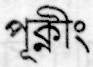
পূক্নীং
